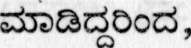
ಮಾಡಿದ್ದರಿಂದ,
